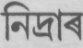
নিদ্ৰাৰ
